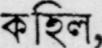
কহিল,
